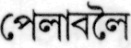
পেলাবলৈ
